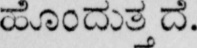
ಹೊಂದುತ್ತದೆ.
